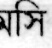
মসি
